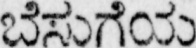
ಬೆಸುಗೆಯ
